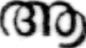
ആ
